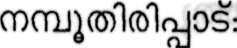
നമ്പൂതിരിപ്പാട്:
